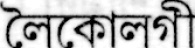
লৈকোলগী
